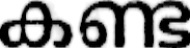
കണ്ട
